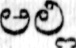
ಅಲ್ಲಿ
